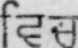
ਵਿਚ
